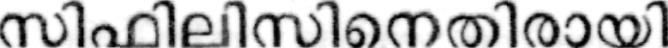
സിഫിലിസിനെതിരായി
